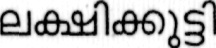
ലക്ഷിക്കുട്ടി
